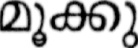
മൂക്കു
